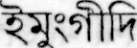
ইমুংগীদি
